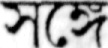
সঙ্গে
